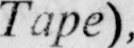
Tape),
